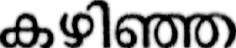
കഴിഞ്ഞ
